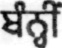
ਬੰਨ੍ਹੀਂ
